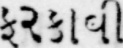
ફરકાવી
